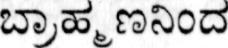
ಬ್ರಾಹ್ಮಣನಿಂದ
